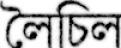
লৈচিল
